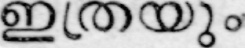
ഇത്രയും
